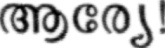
ആര്യേ!
